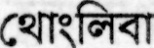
থোংলিবা
